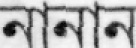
নানান
